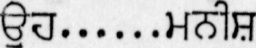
ਉਹ.........ਮਨੀਸ਼
